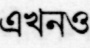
এখনও
